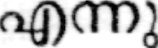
എന്നു
